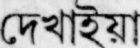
দেখাইয়া
